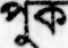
পুক
